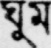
ঘুম
